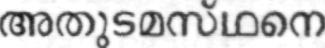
അതുടമസ്ഥനെ
